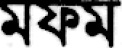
মফম
